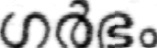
ഗര്‍ഭം
